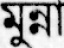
মুন্না
